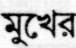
মুখের
